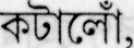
কটালোঁ,
